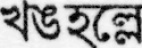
খঙহল্লে
